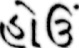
હોઉં
